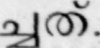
ച്ചത്.
